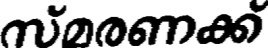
സ്മരണക്ക്
